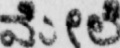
ಮೇಲೆ
